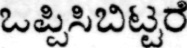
ಒಪ್ಪಿಸಿಬಿಟ್ಟರೆ
